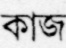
কাজ
